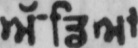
ਅੱਡਿਆਂ
